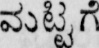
ಮಟ್ಟಿಗೆ
